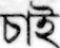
চাই
